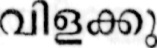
വിളക്കു
